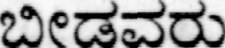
ಬೀಡವರು
